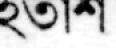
হতাশ
